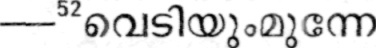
-52വെടിയുംമുന്നേ
